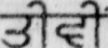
ਤੀਵੀਂ
